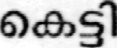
കെട്ടി
